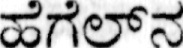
ಹೆಗೆಲ್‌ನ
